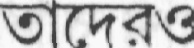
তাদেরও
